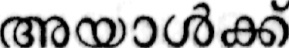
അയാള്‍ക്ക്
